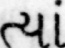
ત્યાં
